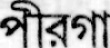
পীরগা
